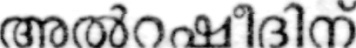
അല്‍റഷീദിന്
